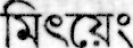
মিৎয়েং
